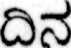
ದಿನ
